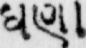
ઘણા
